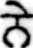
ਨੇ
